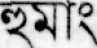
হুমাং
